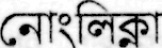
নোংলিক্লা
